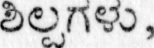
ಶಿಲ್ಪಗಳು,
